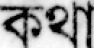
কথা
